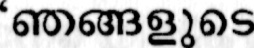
‘ഞങ്ങളുടെ
